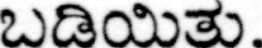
ಬಡಿಯಿತು.
